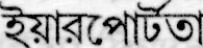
ইয়ারপোর্টতা
